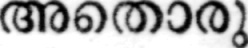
അതൊരു
